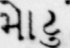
મોટું
